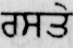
ਰਸਤੇ
